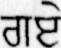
ਗਏ
